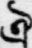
ঐ
